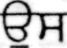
ਉਸ
